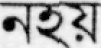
নহয়
